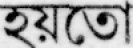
হয়তো
